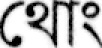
থোং
